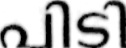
പിടി
